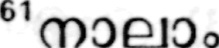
61നാലാം
